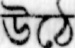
উঠে
